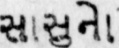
સાસુનો
